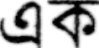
এক
